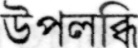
উপলব্ধি
